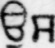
ਉਸ
